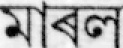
মাৰল
